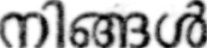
നിങ്ങള്‍
